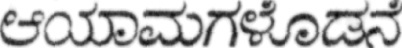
ಆಯಾಮಗಳೊಡನೆ
